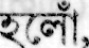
হলোঁ,
